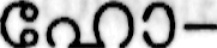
ഹോ-
